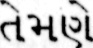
તેમણે
